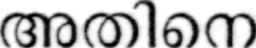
അതിനെ
